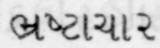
ભ્રષ્ટાચાર
